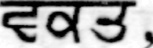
ਵਕਤ,
